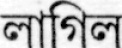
লাগিল
